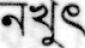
নখুৎ
